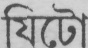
যিটো
